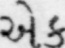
એક
